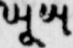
ખૂબ
